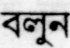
বলুন
